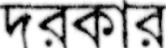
দরকার
